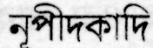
নূপীদকাদি
